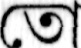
তো
